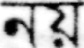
নয়
